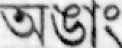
অঙাং
